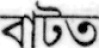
বাটত
